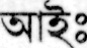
আইঃ
